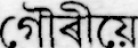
গৌৰীয়ে
